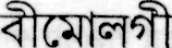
বীমোলগী
